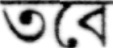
তবে
